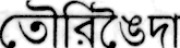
তৌরিঙৈদা
